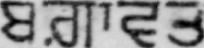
ਬਗ਼ਾਵਤ
